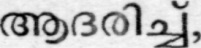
ആദരിച്ച്,
